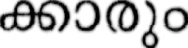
ക്കാരും
